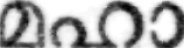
മഹാ
